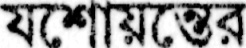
যশোয়ন্তের
